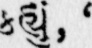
કહ્યું,
